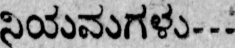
ನಿಯಮಗಳು---
